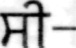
ਸੀ-
